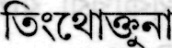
তিংথোক্তুনা
